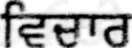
ਵਿਚਾਰ
